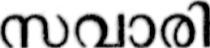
സവാരി
